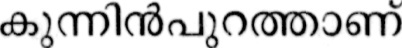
കുന്നിന്‍പുറത്താണ്
